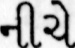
નીચે
